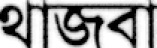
থাজবা
